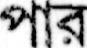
পার
